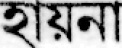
হায়না
